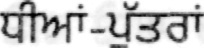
ਧੀਆਂ-ਪੁੱਤਰਾਂ
